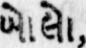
બોલો,
